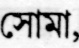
সোমা,
